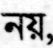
নয়,
